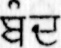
ਬੰਦ
